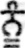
ਨੂੰ
